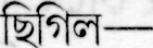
ছিগিল-
